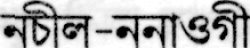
নচীল-ননাওগী
